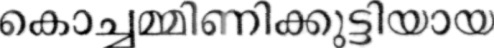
കൊച്ചമ്മിണിക്കുട്ടിയായ
